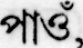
পাওঁ,
